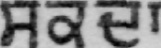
ਸਕਦਾ
